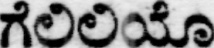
ಗೆಲಿಲಿಯೊ
